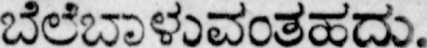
ಬೆಲೆಬಾಳುವಂತಹದು.
